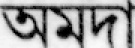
অমদা
